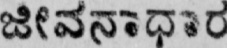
ಜೀವನಾಧಾರ
